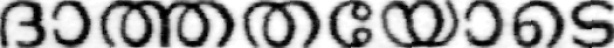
ദാത്തതയോടെ
